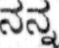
ನನ್ನ
